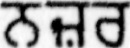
ਨਜ਼ਰ
